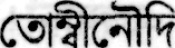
তোম্বীনৌদি
